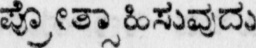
ಪ್ರೋತ್ಸಾಹಿಸುವುದು
